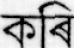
কৰি
